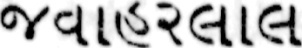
જવાહરલાલ
